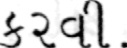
કરવી.
